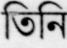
তিনি
